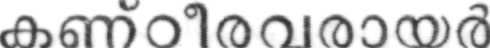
കണ്ഠീരവരായര്‍
